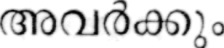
അവര്‍ക്കും
